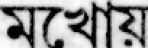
মখোয়
